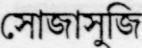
সোজাসুজি
